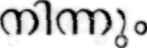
നിന്നും
